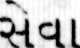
સેવા
